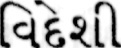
વિદેશી
